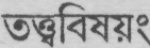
তত্ত্ববিষয়ং
